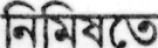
নিমিষতে
